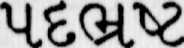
પદભ્રષ્ટ
